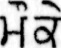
ਮੌਕੇ
